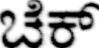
ಚೆಕ್
